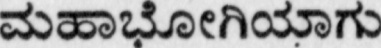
ಮಹಾಭೋಗಿಯಾಗು
